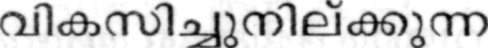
വികസിച്ചുനില്ക്കുന്ന
